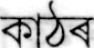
কাঠৰ
